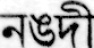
নঙদী
